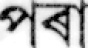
পৰা
